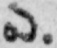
ಎ.
